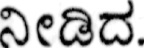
ನೀಡಿದ.
